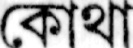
কোথা
